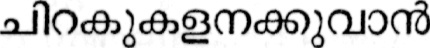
ചിറകുകളനക്കുവാന്‍
